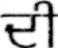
ਦੀ
